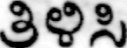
ತಿಳಿಸಿ
